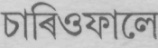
চাৰিওফালে
